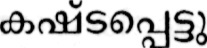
കഷ്ടപ്പെട്ടു
